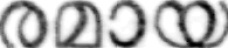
രമായ
